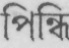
পিন্ধি
